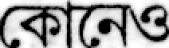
কোনেও
